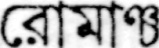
রোমাঞ্চ
